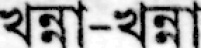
খন্না-খন্না
